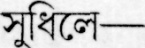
সুধিলে-
